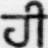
ਹੀ
